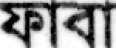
ফাবা
